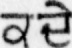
ਕਦੇ
